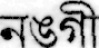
নঙগী
